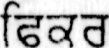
ਫਿਕਰ
